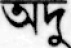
অদু
